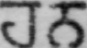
ਹਨ
